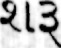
શરૂ
